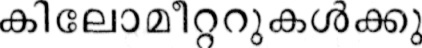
കിലോമീറ്ററുകള്‍ക്കു
